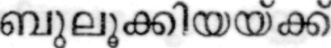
ബുലൂക്കിയയ്ക്ക്
